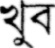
খুব
